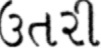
ઉતરી
